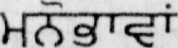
ਮਨੋਭਾਵਾਂ
